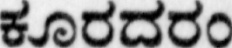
ಕೂರದರಂ
